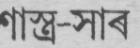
শাস্ত্ৰ-সাৰ
